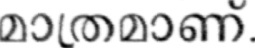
മാത്രമാണ്.
